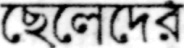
ছেলেদের
